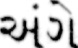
અંગે
